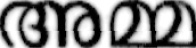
അമ്മ
